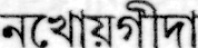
নখোয়গীদা
